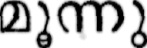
മൂന്നു
